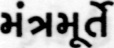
મંત્રમૂર્તે
